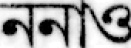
ননাও
